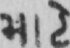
માટે
